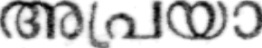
അപ്രയാ
